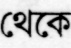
থেকে
